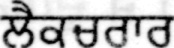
ਲੈਕਚਰਾਰ
